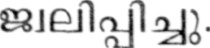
ജ്വലിപ്പിച്ചു.
